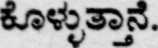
ಕೊಳ್ಳುತ್ತಾನೆ.
